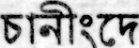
চানীংদে
